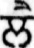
ਲੈ
